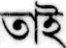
তাই
